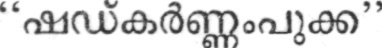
"ഷഡ്കര്‍ണ്ണംപുക്ക"
